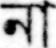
না
